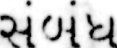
સંબંધ
